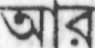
আর
